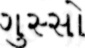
ગુસ્સો
